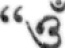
"ওঁ
